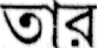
তার
